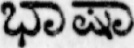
ಭಾಷಾ
